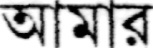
আমার
